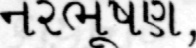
નરભૂષણ,
